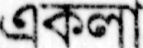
একলা
